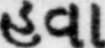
હવા
